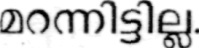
മറന്നിട്ടില്ല.
